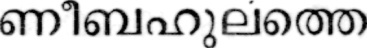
ണീബഹുലത്തെ
